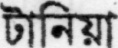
টানিয়া
